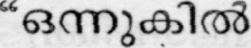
"ഒന്നുകില്‍
